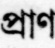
প্রাণ
